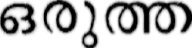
ഒരുത്ത
